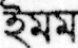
ইমম
